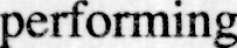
performing
